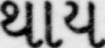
થાય
